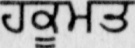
ਹਕੂਮਤ
